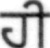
ਹੀ
